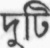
দুটি
